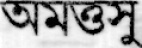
অমত্তসু
